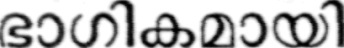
ഭാഗികമായി
